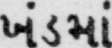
ખંડમાં
